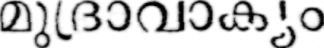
മുദ്രാവാക്യം
